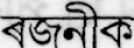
ৰজনীক
